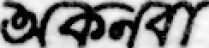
অকনবা
